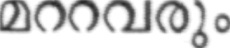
മററവരും
